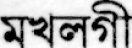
মখলগী
